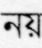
নয়
